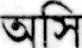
অসি
